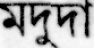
মদুদা
